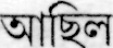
আছিল
